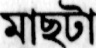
মাছটা
